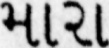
મારા
